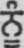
ਨੂੰ
